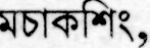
মচাকশিং,
